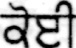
ਕੋਈ
